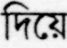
দিয়ে
